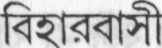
বিহারবাসী
